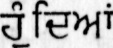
ਹੁੰਦਿਆਂ
